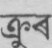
ক্ৰুৰ
